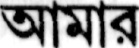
আমার
